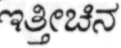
ಇತ್ತೀಚಿನ
